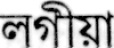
লগীয়া
